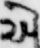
એ
